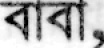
বাবা,
